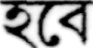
হবে
